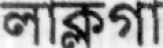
লাক্লগা
